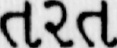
તરત
